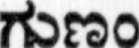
ಗುಣಂ
